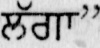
ਲੱਗਾ''
